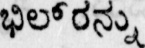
ಭಿಲ್‌ರನ್ನು
